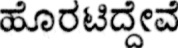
ಹೊರಟಿದ್ದೇವೆ
